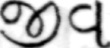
જીવ
